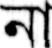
না
